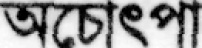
অচোৎপা
